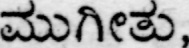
ಮುಗೀತು,
